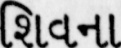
શિવના
